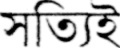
সত্যিই
